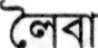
লৈবা
